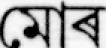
মোৰ
